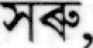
সৰু,
